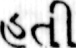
હતી
